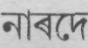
নাৰদে
